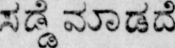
ಸಡ್ಡೆಮಾಡದೆ
